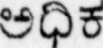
ಅಧಿಕ
